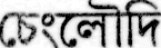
চেংলৌদি
